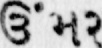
ઉંમર
